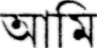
আমি
